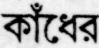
কাঁধের
